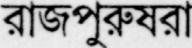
রাজপুরুষরা
